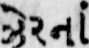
ઝેરનાં
